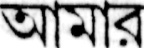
আমার
